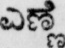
ಎಣ್ಣೆ
